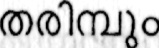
തരിമ്പും
